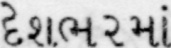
દેશભરમાં
